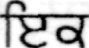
ਇਕ
